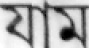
যাম
